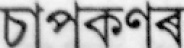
চাপকণৰ
